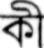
কী
